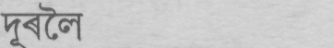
দূৰলৈ
